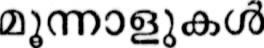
മൂന്നാളുകള്‍
